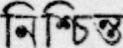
নিশ্চিন্ত
